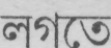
লগতে
